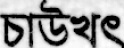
চাউখৎ
